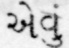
એવું
